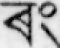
ৰং
